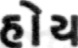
હોય
